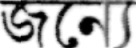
জন্যে
